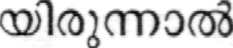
യിരുന്നാല്‍
